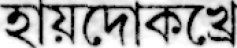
হায়দোকখ্রে
